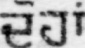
ਦੋਹਾਂ
